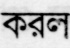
করল
